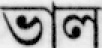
ভাল
